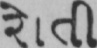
રોતી
